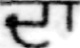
ਦਾ
